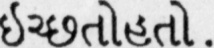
ઇચ્છતોહતો.
